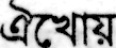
ঐখোয়
